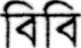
বিবি
